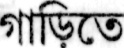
গাড়িতে
